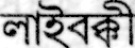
লাইবক্কী
